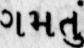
ગમતું
